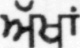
ਅੱਖਾਂ
